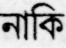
নাকি
